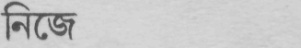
নিজে
